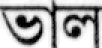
ভাল
